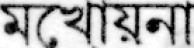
মখোয়না
